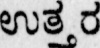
ಉತ್ತರ
